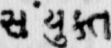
સંયુક્ત
